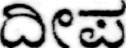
ದೀಪ
